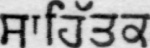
ਸਾਹਿੱਤਕ
